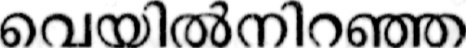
വെയില്‍നിറഞ്ഞ
